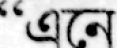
"এনে
